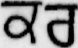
ਕਰ
